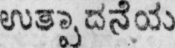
ಉತ್ಪಾದನೆಯ
